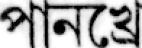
পানখ্রে
